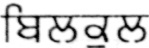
ਬਿਲਕੁਲ
